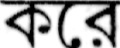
করে
